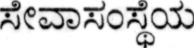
ಸೇವಾಸಂಸ್ಥೆಯ
